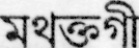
মথক্তগী
